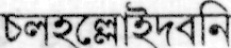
চলহল্লোইদবনি
